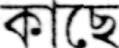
কাছে
